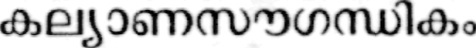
കല്യാണസൌഗന്ധികം
